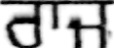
ਰਾਜ
